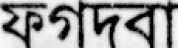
ফগদবা
